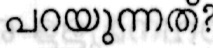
പറയുന്നത്?
